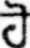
ਹੋ
